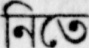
নিতে
